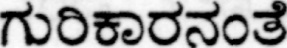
ಗುರಿಕಾರನಂತೆ
